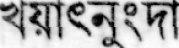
খয়াৎনুংদা
